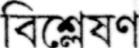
বিশ্লেষণ
